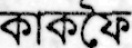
কাকফৈ
